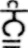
ਨੂੰ
